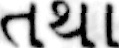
તથા
